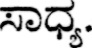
ಸಾಧ್ಯ.
